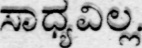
ಸಾಧ್ಯವಿಲ್ಲ.
